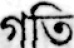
গতি
